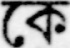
কে
